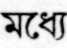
মধ্যে
